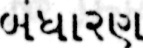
બંધારણ
